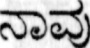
ನಾವು
